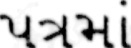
પત્રમાં
